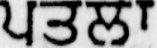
ਪਤਲਾ
